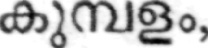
കുമ്പളം,
